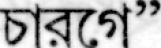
চারগে”
